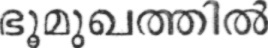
ഭൂമുഖത്തില്‍
